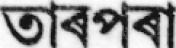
তাৰপৰা
